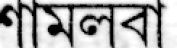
শামলবা
